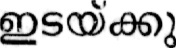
ഇടയ്ക്കു
